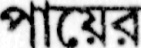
পায়ের
